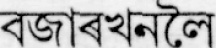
বজাৰখনলৈ
